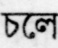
চলে
